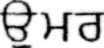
ਉਮਰ
